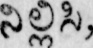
ನಿಲ್ಲಿಸಿ,
